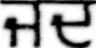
ਜਦ
